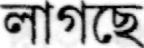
লাগছে
